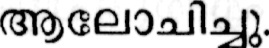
ആലോചിച്ചു.
